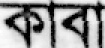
কাবা
